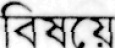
বিষয়ে
